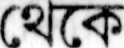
থেকে
